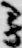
કે
